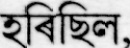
হৰিছিল,
